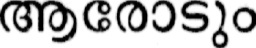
ആരോടും
